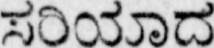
ಸರಿಯಾದ
